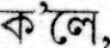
ক'লে,
